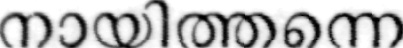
നായിത്തന്നെ
